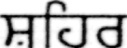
ਸ਼ਹਿਰ
